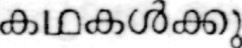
കഥകള്‍ക്കു
